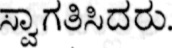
ಸ್ವಾಗತಿಸಿದರು.
